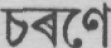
চৰণে
